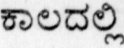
ಕಾಲದಲ್ಲಿ
